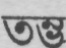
তম্ভ
